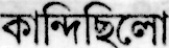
কান্দিছিলো
